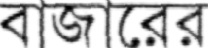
বাজারের
